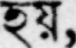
হয়,
